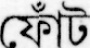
ফোঁট
